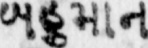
બહુમાન
